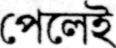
পেলেই
